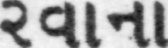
રવાના
